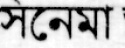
সিনেমা
